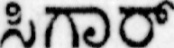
ಸಿಗಾರ್
